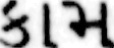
કામ
